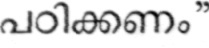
പഠിക്കണം”
